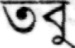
তবু
